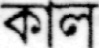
কাল
